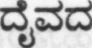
ದೈವದ
